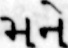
મને
